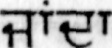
ਜਾਂਦਾ
